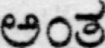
ಅಂತ
